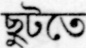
ছুটতে
